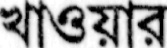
খাওয়ার
